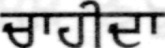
ਚਾਹੀਦਾ
